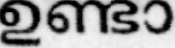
ഉണ്ടാ
